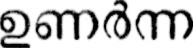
ഉണര്‍ന്ന
